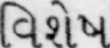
વિશેષ
